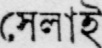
সেলাই
